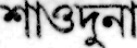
শাওদুনা
